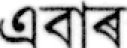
এবাৰ
